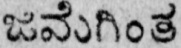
ಜಮೆಗಿಂತ
